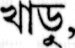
খাড়ু,
